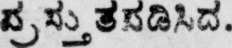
ಪ್ರಸ್ತುತಪಡಿಸಿದ.
